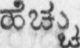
ಹೆಚ್ಚು
